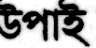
উপাই
